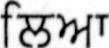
ਲਿਆ
